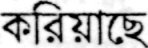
করিয়াছে
